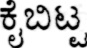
ಕೈಬಿಟ್ಟ
